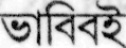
ভাবিবই
